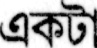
একটা
